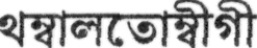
থম্বালতোম্বীগী
